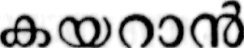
കയറാന്‍
